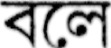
বলে
